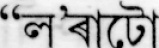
"ল'ৰাটো
